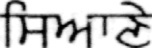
ਸਿਆਣੇ
